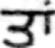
ਤਾਂ
